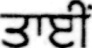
ਤਾਈਂ
